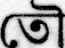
তৌ
